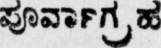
ಪೂರ್ವಾಗ್ರಹ
